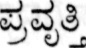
ಪ್ರವೃತ್ತಿ
